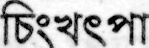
চিংখৎপা
